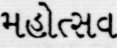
મહોત્સવ
